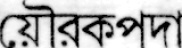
য়ৌরকপদা
